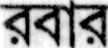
রবার
